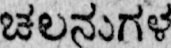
ಚಲನುಗಳ
